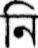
নি
